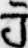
ਹੋ
